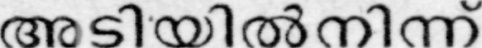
അടിയില്‍നിന്ന്
